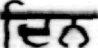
ਦਿਨ
